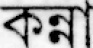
কন্না
